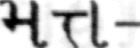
મત્ત-
